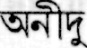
অনীদু
